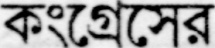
কংগ্রেসের
